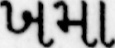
ખમા
